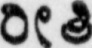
ರೀತಿ
